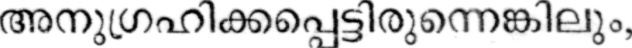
അനുഗ്രഹിക്കപ്പെട്ടിരുന്നെങ്കിലും,
